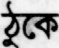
ঠুকে
